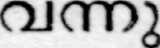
വന്നു
